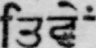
ਤਿਵੇਂ
